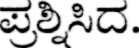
ಪ್ರಶ್ನಿಸಿದ.
